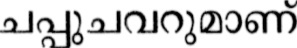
ചപ്പുചവറുമാണ്
